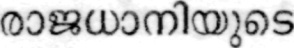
രാജധാനിയുടെ
